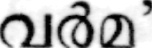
വര്‍മ'
